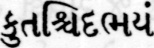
કુતશ્ચિદભયં
